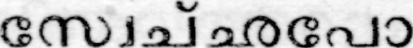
സ്വേച്ഛപോ
